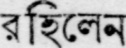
রহিলেন
